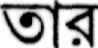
তার
